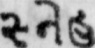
સ્નેહ
